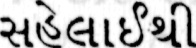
સહેલાઈથી
